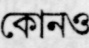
কোনও
